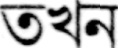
তখন
